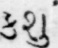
કશું
